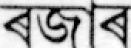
ৰজাৰ
